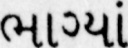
ભાગ્યાં
